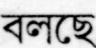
বলছে
